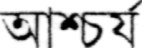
আশ্চর্য
